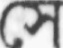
সে
